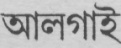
আলগাই
